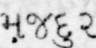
મજદુર
